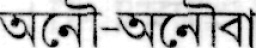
অনৌ-অনৌবা
